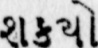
શક્યો
